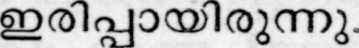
ഇരിപ്പായിരുന്നു.
